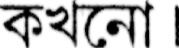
কখনো।
